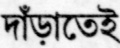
দাঁড়াতেই
